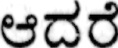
ಆದರೆ
